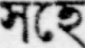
সহে
